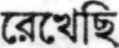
রেখেছি
